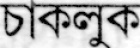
চাকলুক
